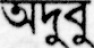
অদুবু
